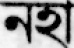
নহা
